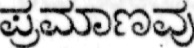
ಪ್ರಮಾಣವು
